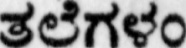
ತಲೆಗಳಂ
